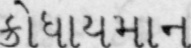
ક્રોધાયમાન
